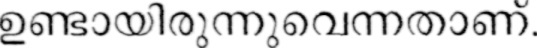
ഉണ്ടായിരുന്നുവെന്നതാണ്.
